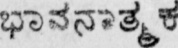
ಭಾವನಾತ್ಮಕ
